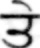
ਤੇ
